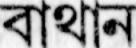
বাথান
